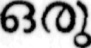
ഒരു
